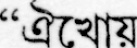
“ঐখোয়
